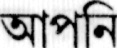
আপনি
